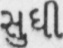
સુધી
